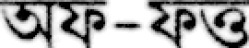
অফ-ফত্ত
